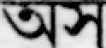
অস
